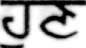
ਹੁਣ
